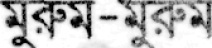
মুরুম-মুরুম
